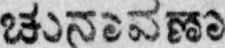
ಚುನಾವಣಾ
